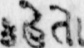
કહેતો
